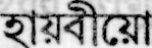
হায়বীয়ো
